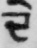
ਦੇ
